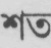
শত
